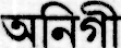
অনিগী
